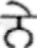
ਨੇ
